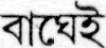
বাঘেই
